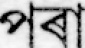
পৰা
